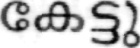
കേട്ടു
